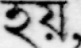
হয়,
